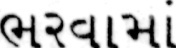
ભરવામાં
